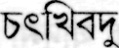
চৎখিবদু
